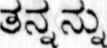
ತನ್ನನ್ನು
